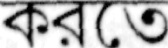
করতে
